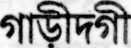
গাড়ীদগী
